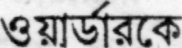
ওয়ার্ডারকে
